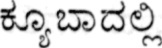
ಕ್ಯೂಬಾದಲ್ಲಿ
